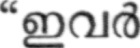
“ഇവര്‍
